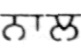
ਨਾਲ
